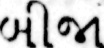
બીજા
